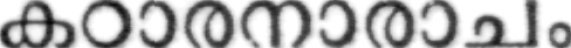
കഠാരനാരാചം
